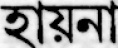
হায়না
